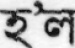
হ'ল
